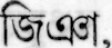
জিঞা,
